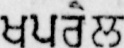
ਖਪਰੈਲ
